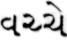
વચ્ચે
